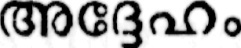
അദ്ദേഹം
